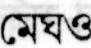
মেঘও
